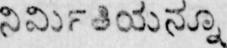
ನಿರ್ಮಿತಿಯನ್ನೂ
